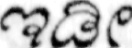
ಇಡೀ
